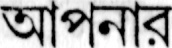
আপনার
